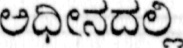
ಅಧೀನದಲ್ಲಿ
